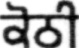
ਕੋਠੀ
